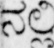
ನಲ್ಲಿ
